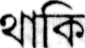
থাকি
